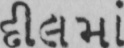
દીલમાં
